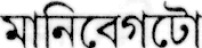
মানিবেগটো
